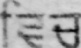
ਵਿਚ
